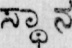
ಸ್ಥಾನ
